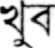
খুব
